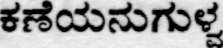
ಕಣೆಯನುಗುಳ್ವ
